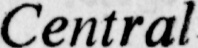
Central
